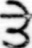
ਤੇ
